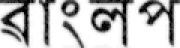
ৱাংলপ
